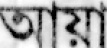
আয়া
